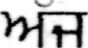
ਅੱਜ
